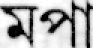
মপা
